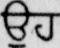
ਉਹ
